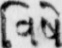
વિષે
